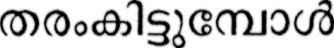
തരംകിട്ടുമ്പോള്‍
